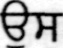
ਉਸ
